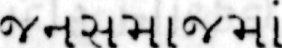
જનસમાજમાં
